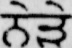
ਨੇੜੇ
